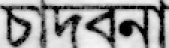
চাদবনা
